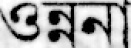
ওন্ননা
